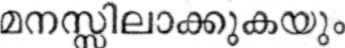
മനസ്സിലാക്കുകയും
